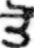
ਤੋਂ
